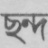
ছন্দ
